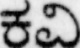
ಕವಿ
